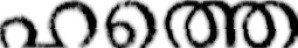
ഹത്തെ
